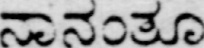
ನಾನಂತೂ
